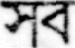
সব
